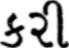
કરી
